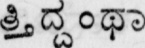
ತ್ತಿದ್ದಂಥಾ
